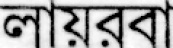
লায়রবা
